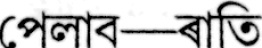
পেলাব-ৰাতি
